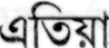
এতিয়া
